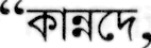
“কান্নদে,
